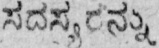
ಸದಸ್ಯರನ್ನು
